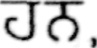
ਹਨ,
